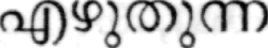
എഴുതുന്ന
